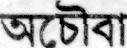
অচৌবা
